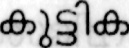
കുട്ടിക
